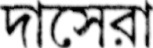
দাসেরা
